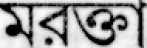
মরক্তা
